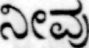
ನೀವು
